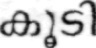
കൂടി
